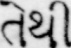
તેથી
